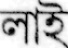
লাই
